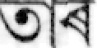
তাৰ
